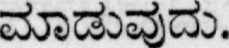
ಮಾಡುವುದು.
